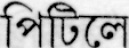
পিটিলে
